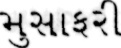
મુસાફરી
